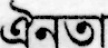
ঐনতা
